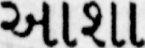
આશા
